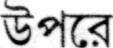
উপরে
